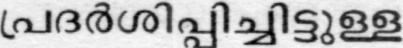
പ്രദര്‍ശിപ്പിച്ചിട്ടുള്ള
